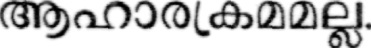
ആഹാരക്രമമല്ല.
